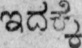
ಇದಕ್ಕೆ
